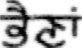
ਭੈਣਾਂ
